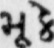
મૂકે
